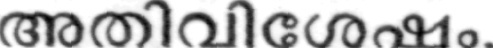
അതിവിശേഷം.
